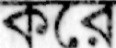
করে
